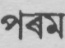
পৰম
